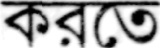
করতে
